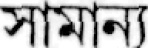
সামান্য
